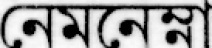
নেমনেম্না
